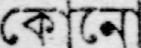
কোনো
